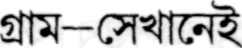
গ্রাম-সেখানেই
